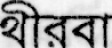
থীরবা
